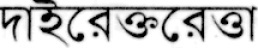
দাইরেক্তরেত্তা
